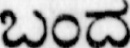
ಬಂದ
